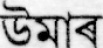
উমাৰ
